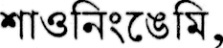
শাওনিংঙেমি,
